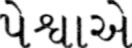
પેશ્વાએ
